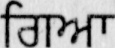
ਗਿਆ
